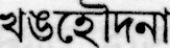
খঙহৌদনা
